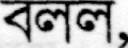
বলল,
